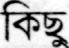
কিছু
